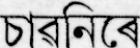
চাৱনিৰে
